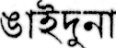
ঙাইদুনা
